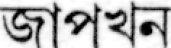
জাপখন
